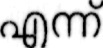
എന്ന്
